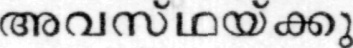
അവസ്ഥയ്ക്കു
